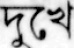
দুখে
